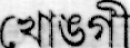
খোঙগী
